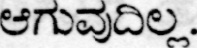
ಆಗುವುದಿಲ್ಲ.
